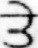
ਤੇ
